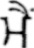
ਮੈਂ
